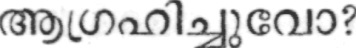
ആഗ്രഹിച്ചുവോ?
